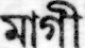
মাগী
